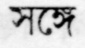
সঙ্গে
